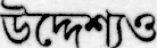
উদ্দেশ্যও
